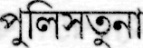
পুলিসতুনা
